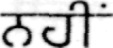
ਨਹੀਂ
